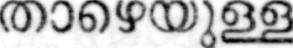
താഴെയുള്ള
